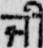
ਜੀ
